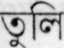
তুলি
